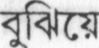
বুঝিয়ে
